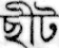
ছীট
